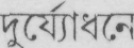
দুৰ্য্যোধনে
